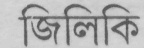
জিলিকি
